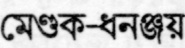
মেণ্ডক-ধনঞ্জয়
